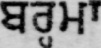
ਬਰ੍ਹਮਾ
